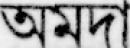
অমদা
